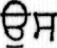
ਉਸ
